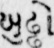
બુઢ્ઢો
